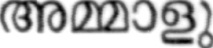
അമ്മാളു
